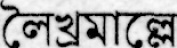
লৈখ্রমাল্লে
